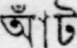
আঁট
